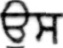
ਉਸ
